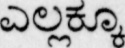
ಎಲ್ಲಕ್ಕೂ
